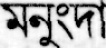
মনুংদা
